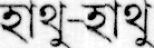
হাথু-হাথু
